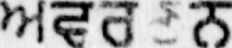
ਅਵਰਣਨ
